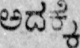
ಅದಕ್ಕೆ
